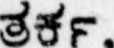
ತರ್ಕ.
